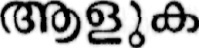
ആളുക
